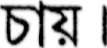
চায়।
